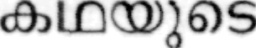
കഥയുടെ
